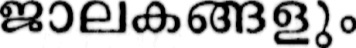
ജാലകങ്ങളും
